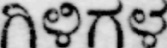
ಗಿಳಿಗಳ
